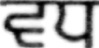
ਵਧ
